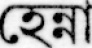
হেন্না
